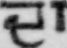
ਦਾ
